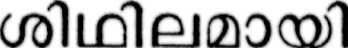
ശിഥിലമായി
